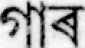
গাৰ
